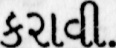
કરાવી.
